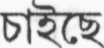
চাইছে
